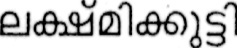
ലക്ഷ്മിക്കുട്ടി
